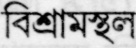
বিশ্রামস্থল
